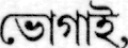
ভোগাই,
